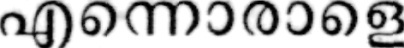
എന്നൊരാളെ
